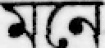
মনে
